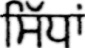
ਸਿੱਧਾਂ
